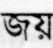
জয়
